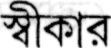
স্বীকার
